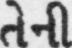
તેની
